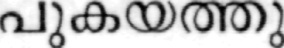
പുകയത്തു
